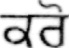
ਕਰੋ
